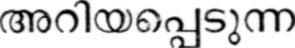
അറിയപ്പെടുന്ന
